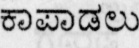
ಕಾಪಾಡಲು
